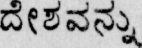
ದೇಶವನ್ನು
